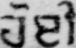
ਹੋਈ
